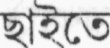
ছাইতে
